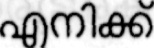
എനിക്ക്
